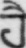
ਹੈ
